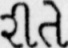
રીતે
